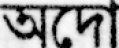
অদো
